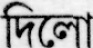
দিলো
